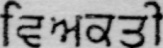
ਵਿਅਕਤੀ
